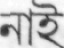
নাই
